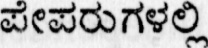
ಪೇಪರುಗಳಲ್ಲಿ
